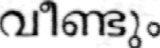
വീണ്ടും
